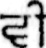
ਵੀ
